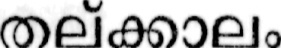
തല്ക്കാലം
